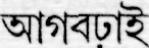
আগবঢ়াই
